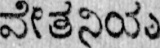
ವೇತನಿಯ
